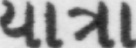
યાત્રા
